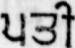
ਪਤੀ
